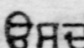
ਉਸਦ
